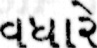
વધારે
